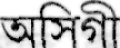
অসিগী
